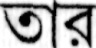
তার
